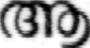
ആ
